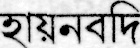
হায়নবদি
